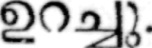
ഉറച്ചു.
